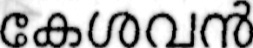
കേശവന്‍
